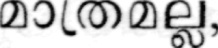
മാത്രമല്ല,
